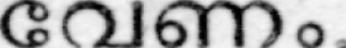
വേണം.
